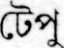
টেপু
